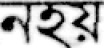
নহয়
